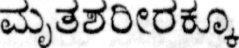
ಮೃತಶರೀರಕ್ಕೂ
